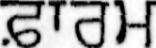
ਫ਼ਾਰਮ
